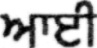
ਆਈ
